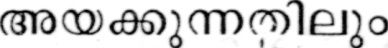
അയക്കുന്നതിലും
